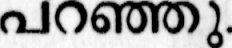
പറഞ്ഞു.
